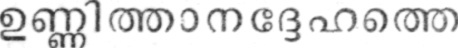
ഉണ്ണിത്താനദ്ദേഹത്തെ
